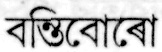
বন্তিবোৰো
